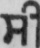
ਸੀ
